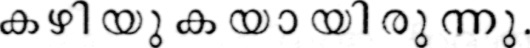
കഴിയുകയായിരുന്നു.
